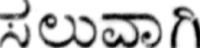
ಸಲುವಾಗಿ
